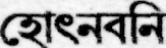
হোৎনবনি
